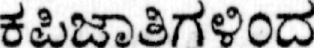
ಕಪಿಜಾತಿಗಳಿಂದ
